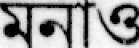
মনাও
